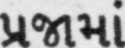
પ્રજામાં
